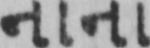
નાના
